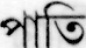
পাতি
